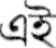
এই
